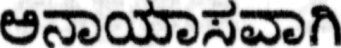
ಅನಾಯಾಸವಾಗಿ
